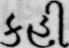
કહી
